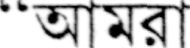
“আমরা
